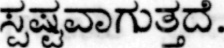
ಸ್ಪಷ್ಟವಾಗುತ್ತದೆ.
